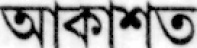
আকাশত
